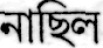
নাছিল
